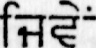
ਜਿਵੇਂ
